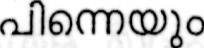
പിന്നെയും
